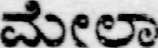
ಮೇಲಾ
